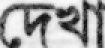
দেখা
